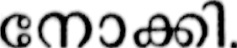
നോക്കി.
